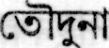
তৌদুনা
